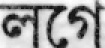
লগে
